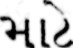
માટે
